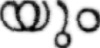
യും
